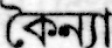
কৈন্যা
